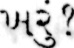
ખરું?
